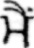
ਮੈਂ
